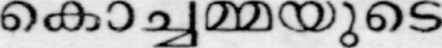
കൊച്ചമ്മയുടെ
